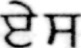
ਏਸ
